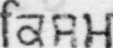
ਕਿਸਮ
